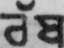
ਰੱਬ
